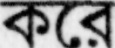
করে
